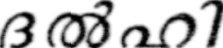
ദല്‍ഹി
